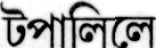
টপালিলে
